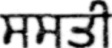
ਸਸਤੀ
